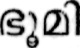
ഭൂമി
